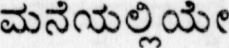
ಮನೆಯಲ್ಲಿಯೇ
